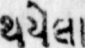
થયેલા
